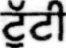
ਟੁੱਟੀ
